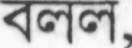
বলল,
